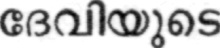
ദേവിയുടെ
